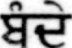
ਬੰਦੇ
